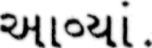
આવ્યાં.
